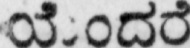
ಯೆಂದರೆ
